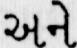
અને
